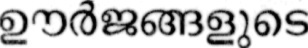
ഊര്‍ജങ്ങളുടെ
